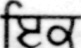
ਇਕ
